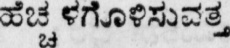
ಹೆಚ್ಚಳಗೊಳಿಸುವತ್ತ
